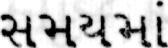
સમયમાં
